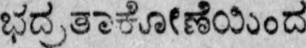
ಭದ್ರತಾಕೋಣೆಯಿಂದ
